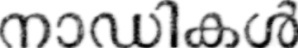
നാഡികള്‍
